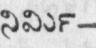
ನಿರ್ಮಿ-
